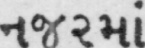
નજરમાં
